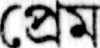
প্রেম
